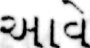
આવે
